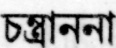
চন্ত্রাননা
